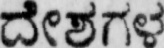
ದೇಶಗಳ
